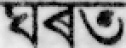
ঘৰত
